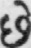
છે
